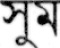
সুম
